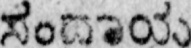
ಸಂದಾಯ
